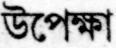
উপেক্ষা
